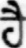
ਹੈ
